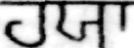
ਹਯਾ
